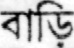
বাড়ি
